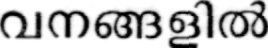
വനങ്ങളില്‍
